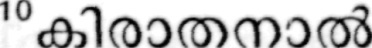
10കിരാതനാല്‍
